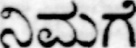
ನಿಮಗೆ
